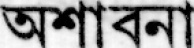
অশাবনা
